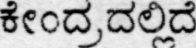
ಕೇಂದ್ರದಲ್ಲಿದೆ
